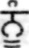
ਨੂੰ
